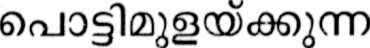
പൊട്ടിമുളയ്ക്കുന്ന
